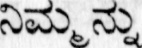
ನಿಮ್ಮನ್ನು
